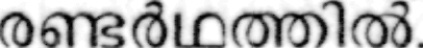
രണ്ടര്‍ഥത്തില്‍.
